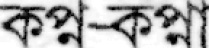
কপ্ন-কপ্না
